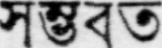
সম্ভবত
